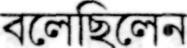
বলেছিলেন
